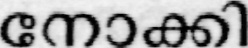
നോക്കി
